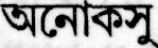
অনোকসু
